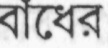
বাধের
